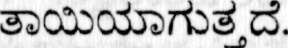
ತಾಯಿಯಾಗುತ್ತದೆ.
